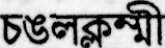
চঙলক্লম্মী
